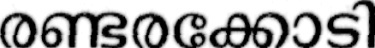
രണ്ടരക്കോടി
